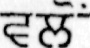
ਵਲੋਂ
